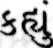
કહ્યું
